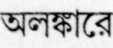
অলঙ্কারে
